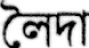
লৈদা
